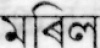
মৰিল
